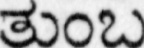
ತುಂಬ
